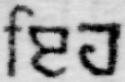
ਇਹ
